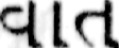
વાત
